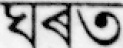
ঘৰত
